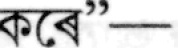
কৰে"-
